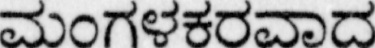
ಮಂಗಳಕರವಾದ
